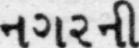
નગરની
